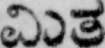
ಮಿತ
